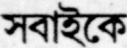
সবাইকে
